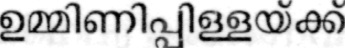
ഉമ്മിണിപ്പിള്ളയ്ക്ക്
